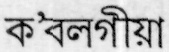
ক'বলগীয়া
